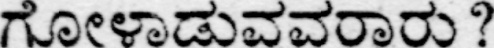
ಗೋಳಾಡುವವರಾರು?
